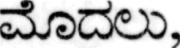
ಮೊದಲು,
